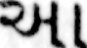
આ
